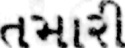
તમારી
